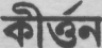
কীৰ্ত্তন
